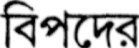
বিপদের
